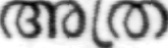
അത്ര
